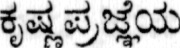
ಕೃಷ್ಣಪ್ರಜ್ಞೆಯ
